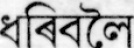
ধৰিবলৈ
